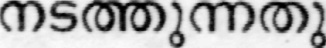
നടത്തുന്നതു
